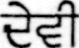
ਦੇਵੀ
